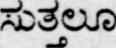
ಸುತ್ತಲೂ
